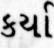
કર્યા
